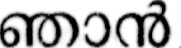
ഞാന്‍
